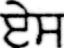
ਏਸ
